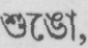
শুঙো,
